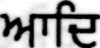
ਆਦਿ
